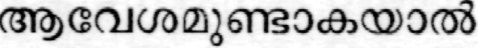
ആവേശമുണ്ടാകയാല്‍
